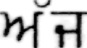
ਅੱਜ
